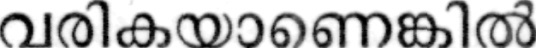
വരികയാണെങ്കില്‍
